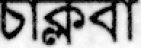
চাক্লবা
